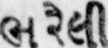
ભરેલી
